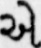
એ
